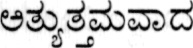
ಅತ್ಯುತ್ತಮವಾದ
